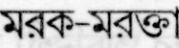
মরক-মরক্তা
